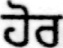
ਹੋਰ
